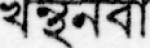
খন্থনবা
